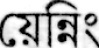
য়েন্নিং
